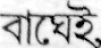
বাঘেই,
